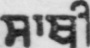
ਸਾਥੀ
